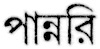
পান্নরি
